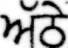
ਅੱਠੇ
